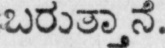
ಬರುತ್ತಾನೆ.
